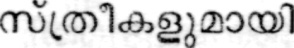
സ്ത്രീകളുമായി
